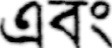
এবং
